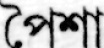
পৈশা
